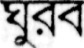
ঘুরব
